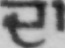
ਦਾ
